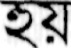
হয়
